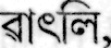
ৱাৎলি,
